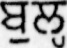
ਬੁਲ੍ਹ
